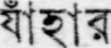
যাঁহার
